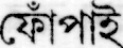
ফোঁপাই
